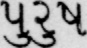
પુરુષ
